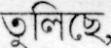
তুলিছে,
